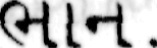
ભાન.
